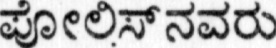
ಪೋಲಿಸ್‌ನವರು
